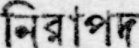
নিরাপদ
